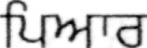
ਪਿਆਰ
